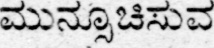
ಮುನ್ಸೂಚಿಸುವ
